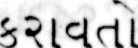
કરાવતો
